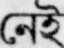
নেই
